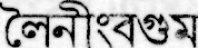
লৈনীংবগুম
